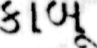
કાબૂ
